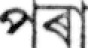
পৰা
